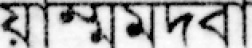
য়াম্মমদবা
